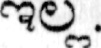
ಇಲ್ಲ.
